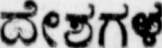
ದೇಶಗಳ
